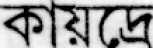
কায়দ্রে
